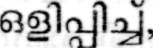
ഒളിപ്പിച്ച്,
